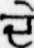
ਦੇ
